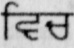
ਵਿਚ
